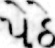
પેઠે
